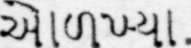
ઓળખ્યા.
